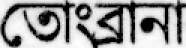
তোংব্রানা
